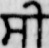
ਸੀ
